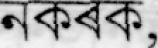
নকৰক,
